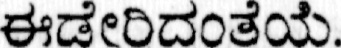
ಈಡೇರಿದಂತೆಯೆ.
